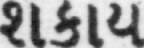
શકાય
